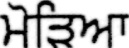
ਮੋੜਿਆ
